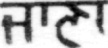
ਜਾਣਾ
